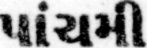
પાંચમી
